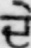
ਦੇ
